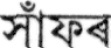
সাঁফৰ
